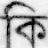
কি
